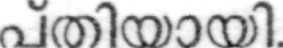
പ്തിയായി.
